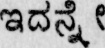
ಇದನ್ನೇ
